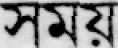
সময়
